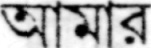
আমার
